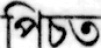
পিচত
